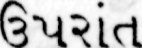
ઉપરાંત
